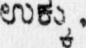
ಉಕ್ಕು,
